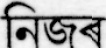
নিজৰ
